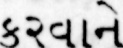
કરવાને
